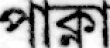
পাক্না
